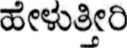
ಹೇಳುತ್ತೀರಿ
